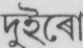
দুইৰো
